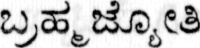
ಬ್ರಹ್ಮಜ್ಯೋತಿ
